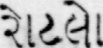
રોટલો
